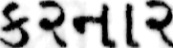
કરનાર
